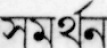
সমৰ্থন
